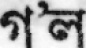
গ'ল
